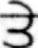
ਤੇ
